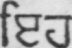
ਇਹ
